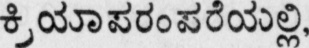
ಕ್ರಿಯಾಪರಂಪರೆಯಲ್ಲಿ,
